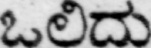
ಒಲಿದು
